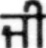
ਜੀ
